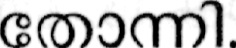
തോന്നി.
